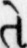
તે
